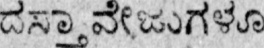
ದಸ್ತಾವೇಜುಗಳೂ
